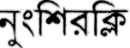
নুংশিরক্লি
